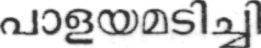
പാളയമടിച്ചി
